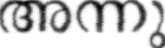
അന്നു
